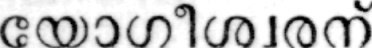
യോഗീശ്വരന്
